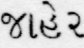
જાહેર
